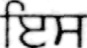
ਇਸ
